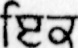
ਇਕ
